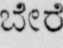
ಬೇರೆ
